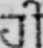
ਹੀ
